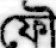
ফৌ
